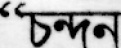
"চন্দন
